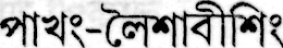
পাখং-লৈশাবীশিং
